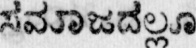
ಸಮಾಜದಲ್ಲೂ
